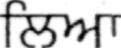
ਲਿਆ
